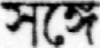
সঙ্গে
